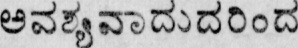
ಅವಶ್ಯವಾದುದರಿಂದ
